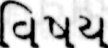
વિષય
